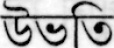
উভতি
